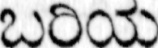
ಬರಿಯ
